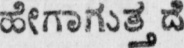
ಹೇಗಾಗುತ್ತದೆ
